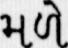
મળે
